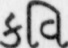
કવિ
